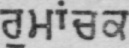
ਰੁਮਾਂਚਕ
